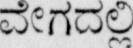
ವೇಗದಲ್ಲಿ
